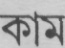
কাম
